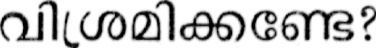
വിശ്രമിക്കണ്ടേ?
